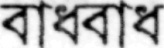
বাধবাধ
